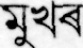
মুখৰ
